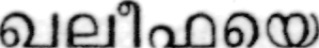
ഖലീഫയെ
